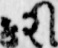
કરી
